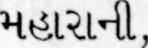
મહારાની,
